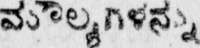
ಮೌಲ್ಯಗಳನ್ನು
